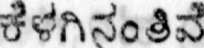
ಕೆಳಗಿನಂತಿವೆ
